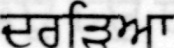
ਦਰੜਿਆ
